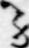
કે
